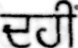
ਦਹੀਂ
